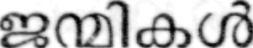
ജന്മികള്‍
